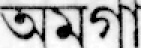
অমগা
